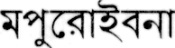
মপুরোইবনা
